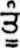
ਤੂੰ
